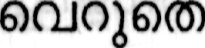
വെറുതെ
